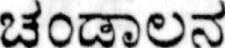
ಚಂಡಾಲನ
